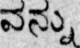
ವನ್ನು
